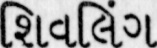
શિવલિંગ
